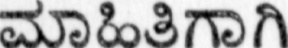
ಮಾಹಿತಿಗಾಗಿ
